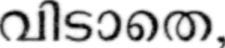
വിടാതെ,
